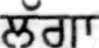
ਲੱਗਾ
